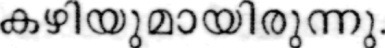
കഴിയുമായിരുന്നു.
